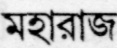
মহারাজ
